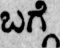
ಬಗ್ಗೆ
